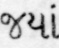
જ્યાં
